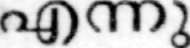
എന്നു
